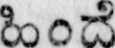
ಹಿಂದೆ
